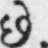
છે.
